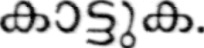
കാട്ടുക.
